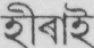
হীৰাই
